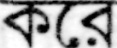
করে
